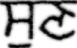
ਸੁਣ
